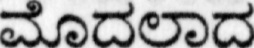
ಮೊದಲಾದ
